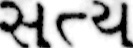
સત્ય
